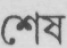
শেষ
